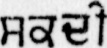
ਸਕਦੀ
